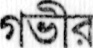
গভীর
